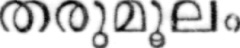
തരുമൂലം
